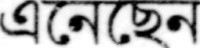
এনেছেন
